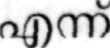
എന്ന്
